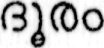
ദൂരം
